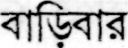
বাড়িবার
